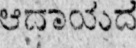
ಆದಾಯದ
